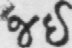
જઈ
